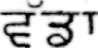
ਵੱਡਾ
